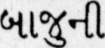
બાજુની
